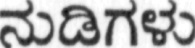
ನುಡಿಗಳು
